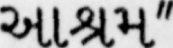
આશ્રમ"
